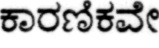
ಕಾರಣಿಕವೇ
